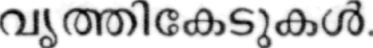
വൃത്തികേടുകള്‍.
